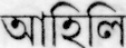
আহিলি
